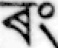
ৰং
